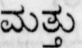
ಮತ್ತು
